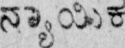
ನ್ಯಾಯಿಕ
